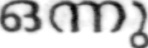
ഒന്നു
